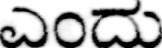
ಎಂದು
